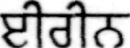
ਈਰੀਨ
